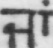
ਜਾਂ
